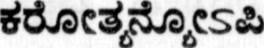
ಕರೋತ್ಯನ್ಯೋsಪಿ
